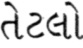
તેટલો
